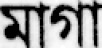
মাগী
